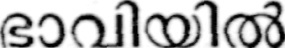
ഭാവിയില്‍
